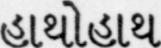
હાથોહાથ
